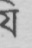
যি
